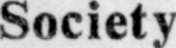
Society
